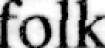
folk
